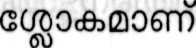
ശ്ലോകമാണ്
